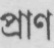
প্ৰাণ
